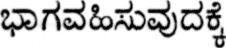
ಭಾಗವಹಿಸುವುದಕ್ಕೆ
